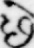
છે
